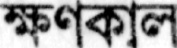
ক্ষণকাল
